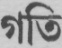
গতি
